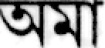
অমা
